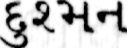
દુશ્મન
